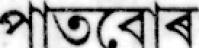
পাতবোৰ
